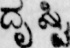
ದೃಷ್ಟಿ
